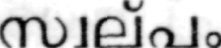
സ്വല്പം
